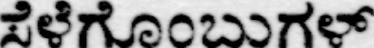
ಸೆಳೆಗೊಂಬುಗಳ್
